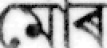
মোৰ
